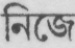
নিজে
